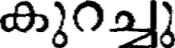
കുറച്ചു
